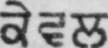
ਕੇਵਲ
